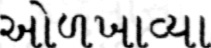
ઓળખાવ્યા
